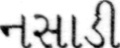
નસાડી
